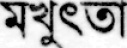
মখুৎতা
